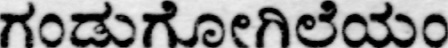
ಗಂಡುಗೋಗಿಲೆಯಂ
